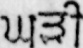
ਘੜੀ
